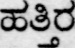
ಹತ್ತಿರ
